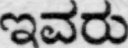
ಇವರು
